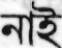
নাই
